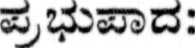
ಪ್ರಭುಪಾದ:
